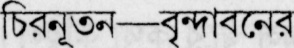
চিরনূতন-বৃন্দাবনের
